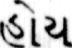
હોય
